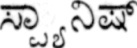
ಸ್ಪ್ಯಾನಿಷ್
